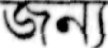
জন্য
